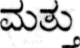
ಮತ್ತು
